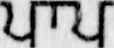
ਪਾਪ
